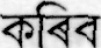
কৰিব
